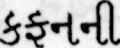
કફનની
